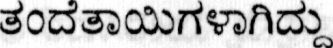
ತಂದೆತಾಯಿಗಳಾಗಿದ್ದು
